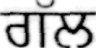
ਗੱਲ
